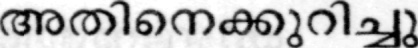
അതിനെക്കുറിച്ചു
